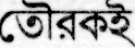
তৌরকই
